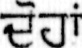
ਦੋਹਾਂ
